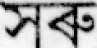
সৰু
